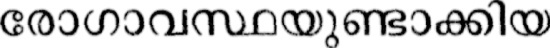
രോഗാവസ്ഥയുണ്ടാക്കിയ
